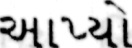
આપ્યો
